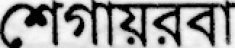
শেগায়রবা
